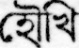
হৌখি
